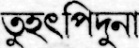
তুহৎপিদুনা
